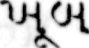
ખૂબ
